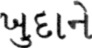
ખુદાને
